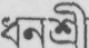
ধনশ্ৰী
